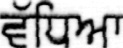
ਵੱਧਿਆ
